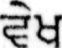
ਵੇਖ
